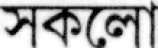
সকলো
